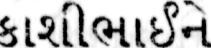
કાશીભાઈને
